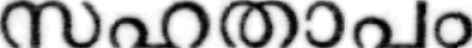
സഹതാപം
